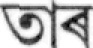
তাৰ
